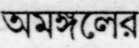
অমঙ্গলের
